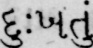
દુઃખતું
